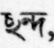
ছন্দ,
